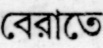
বেরাতে
